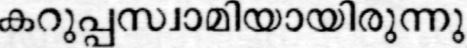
കറുപ്പസ്വാമിയായിരുന്നു
